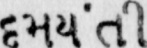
દમયંતી
